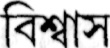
বিশ্বাস
